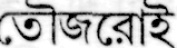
তৌজরোই
